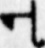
ન
